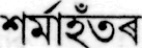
শর্মাহঁতৰ
